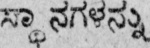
ಸ್ಥಾನಗಳನ್ನು
